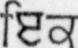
ਇਕ
